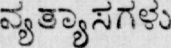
ವ್ಯತ್ಯಾಸಗಳು
